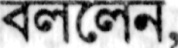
বললেন,
